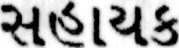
સહાયક
